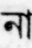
না
